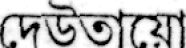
দেউতায়ো
